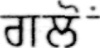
ਗਲੋਂ
